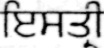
ਇਸਤ੍ਰੀ
